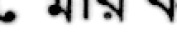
থম্মোয়
